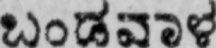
ಬಂಡವಾಳ
